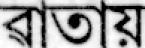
ৱাতায়
